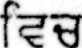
ਵਿਚ
